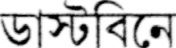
ডাস্টবিনে
